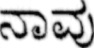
ನಾವು
